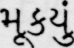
મૂક્યું
